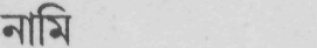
নামি
